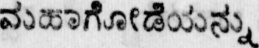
ಮಹಾಗೋಡೆಯನ್ನು
